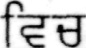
ਵਿਚ
